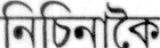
নিচিনাকৈ
